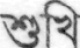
শুখি
